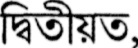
দ্বিতীয়ত,
